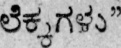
ಲೆಕ್ಕಗಳು”
